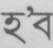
হ'ব
